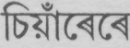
চিয়াঁৰেৰে
